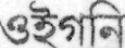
ওইগনি
